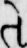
તે
